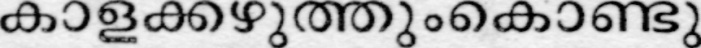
കാളക്കഴുത്തുംകൊണ്ടു
